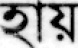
হায়
